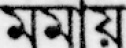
মমায়
